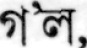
গ'ল,
